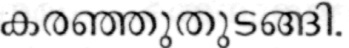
കരഞ്ഞുതുടങ്ങി.
